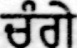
ਚੰਗੇ
